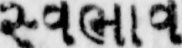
સ્વભાવ
